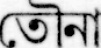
তৌনা
